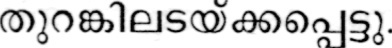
തുറങ്കിലടയ്ക്കപ്പെട്ടു.
